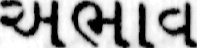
અભાવ
